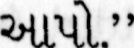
આપો."
